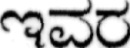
ಇವರ
